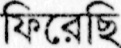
ফিরেছি
